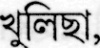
খুলিছা,
